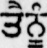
ਤੈਨੂੰ
